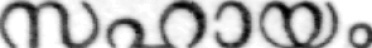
സഹായം
